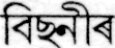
বিছনীৰ
